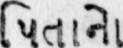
પિતાનો
